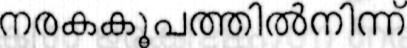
നരകകൂപത്തില്‍നിന്ന്
